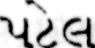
પટેલ
